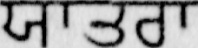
ਯਾਤਰਾ
